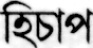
হিচাপ
